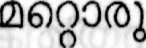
മറ്റൊരു
